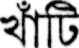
খাঁটি
